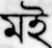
মই
